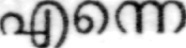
എന്നെ
